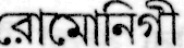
রোমোনিগী
